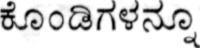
ಕೊಂಡಿಗಳನ್ನೂ
